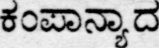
ಕಂಪಾನ್ಯಾದ
